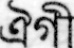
ঐগী
